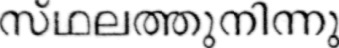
സ്ഥലത്തുനിന്നു
